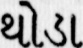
થોડા
